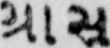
ગ્રાસ
